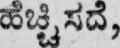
ಹೆಚ್ಚಿಸದೆ,
